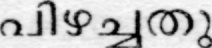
പിഴച്ചതു
